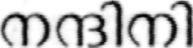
നന്ദിനി
